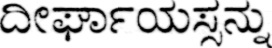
ದೀರ್ಘಾಯಸ್ಸನ್ನು
